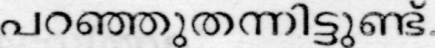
പറഞ്ഞുതന്നിട്ടുണ്ട്.
